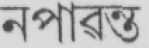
নপাৱন্ত
